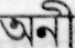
অনী
